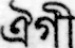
ঐগী
